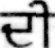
ਦੀ
